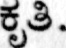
ಕೃತಿ.
